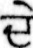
ਦੇ
